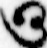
ও
